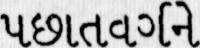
પછાતવર્ગને
